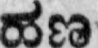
ಹಣ
